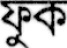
ফুক
